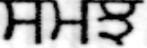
ਸਮਝ
